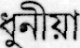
ধুনীয়া
